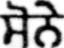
ਸੋਨੇ
